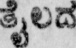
ತೈಲದ
